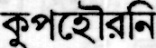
কুপহৌরনি
